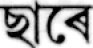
ছাৰে
